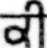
ਕੀ
